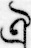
ঐ
